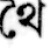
থৈ
